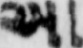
આ
